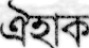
ঐহাক
